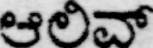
ಆಲಿವ್
